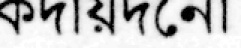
কদায়দনো
